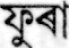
ফুৰা
